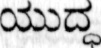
ಯುದ್ಧ
